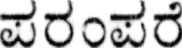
ಪರಂಪರೆ
